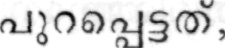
പുറപ്പെട്ടത്,
